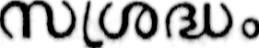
സശ്രദ്ധം
